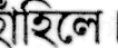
হাঁহিলে
